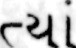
ત્યાં
